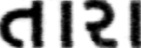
તારા
